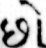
છો
